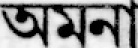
অমনা
